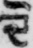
ਦੋ
